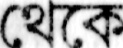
থেকে
